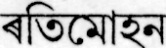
ৰতিমোহন
